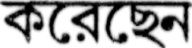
করেছেন
